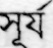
সূর্য
